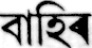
বাহিৰ
